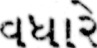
વધારે
